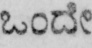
ಒಂದೇ
